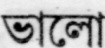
ভালো
